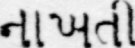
નાખતી
